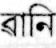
ৱানি
